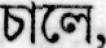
চালে,
